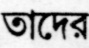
তাদের
